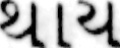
થાય
